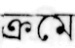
ক্রমে
